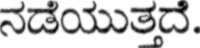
ನಡೆಯುತ್ತದೆ.
